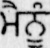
ਮੈਨੂੰ
